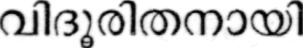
വിദൂരിതനായി
